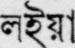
লইয়া
